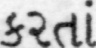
કરતાં
